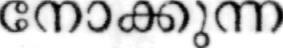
നോക്കുന്ന
